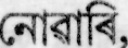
নোৱাৰি,
